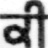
ਕੀ
